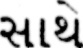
સાથે
